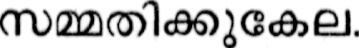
സമ്മതിക്കുകേല.
